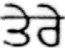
ਤੇਰੇ
